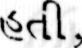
હતી,
